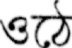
ওঠে
